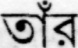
তাঁর
